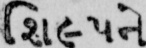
શિલ્પને
